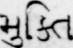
મુક્તિ
